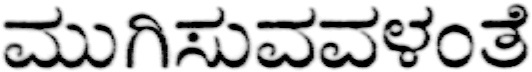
ಮುಗಿಸುವವಳಂತೆ
